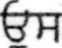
ਉਸ
